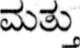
ಮತ್ತು
